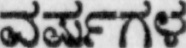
ವರ್ಷಗಳ
